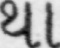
થા
